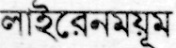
লাইরেনময়ূম
